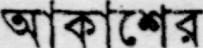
আকাশের
